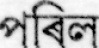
পৰিল
